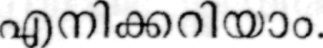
എനിക്കറിയാം.
